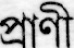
প্রাণী
